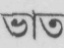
ভাত
